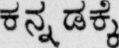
ಕನ್ನಡಕ್ಕೆ
